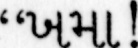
"ખમા!
